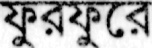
ফুরফুরে
